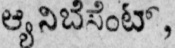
ಆನಿಬೆಸೆಂಟ್,
